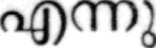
എന്നു
